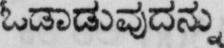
ಓಡಾಡುವುದನ್ನು
